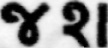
જશ
